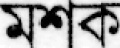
মশক
